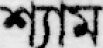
শ্যাম
